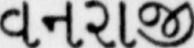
વનરાજી
